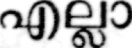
എല്ലാ
